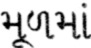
મૂળમાં
